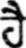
ਹੈ
